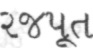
રજપૂત
